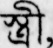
স্ত্রী,
